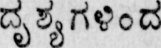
ದೃಶ್ಯಗಳಿಂದ
